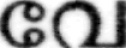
വേ
